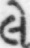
લે
